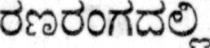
ರಣರಂಗದಲ್ಲಿ
